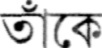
তাঁকে
